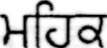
ਮਹਿਕ
